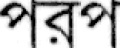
পরপ
